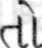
તો
